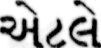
એટલે
